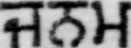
ਜਨਮ
